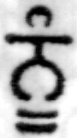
ਨੂੰ
